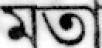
মতা
